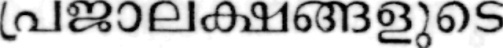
പ്രജാലക്ഷങ്ങളുടെ
